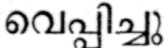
വെപ്പിച്ചു
